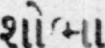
શોભા
